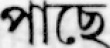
পাছে
